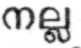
നല്ല
